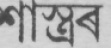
শাস্ত্ৰৰ
